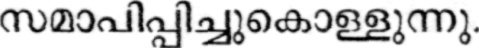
സമാപിപ്പിച്ചുകൊള്ളുന്നു.
